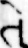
તે
